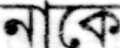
নাকে
